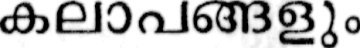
കലാപങ്ങളും
